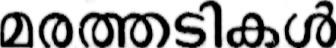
മരത്തടികള്‍
